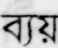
ব্যয়
